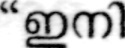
“ഇനി
